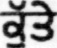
ਕੁੱਤੇ
